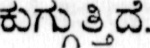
ಕುಗ್ಗುತ್ತಿದೆ.
